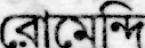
রোমেন্দি
